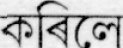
কৰিলে
